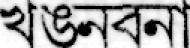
খঙনবনা
